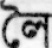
লৈ
